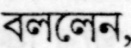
বললেন,
